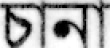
চানা
